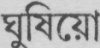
ঘুষিয়ো
